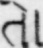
તો
